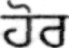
ਹੋਰ
